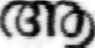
ആ
